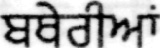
ਬਥੇਰੀਆਂ
